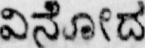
ವಿನೋದ
